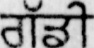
ਗੱਡੀ
